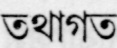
তথাগত
